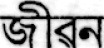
জীৱন
